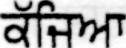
ਕੱਜਿਆ
